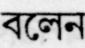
বলেন
